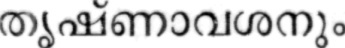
തൃഷ്ണാവശനും
